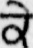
ਕੇ
